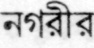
নগরীর
